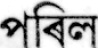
পৰিল
